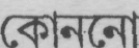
কোননো
